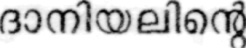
ദാനിയലിന്റെ
